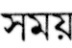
সময়
